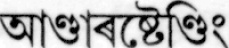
আণ্ডাৰষ্টেণ্ডিং
